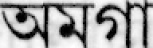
অমগা
